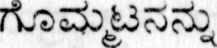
ಗೊಮ್ಮಟನನ್ನು
